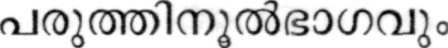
പരുത്തിനൂല്‍ഭാഗവും
